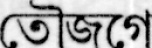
তৌজগে
